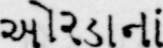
ઓરડાનાં
